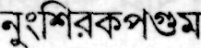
নুংশিরকপগুম
